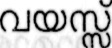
വയസ്സ്
